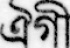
ঐগী
